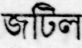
জটিল
